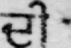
ਦੀ
